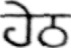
ਹੇਠ
